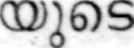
യുടെ
